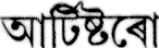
আৰ্টিষ্টৰো
